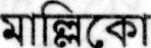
মাল্লিকো
